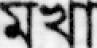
মখা
